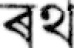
ৰথ
